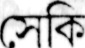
সেকি
